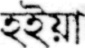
হইয়া
